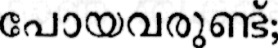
പോയവരുണ്ട്;
